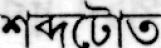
শব্দটোত
